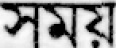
সময়
